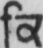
ਕਿ
